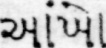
આંખો
